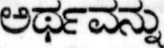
ಅರ್ಥವನ್ನು
